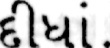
દીધાં.
